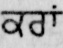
ਕਰਾਂ
